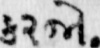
કરજો.
